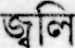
জ্বলি
